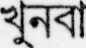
খুনবা
